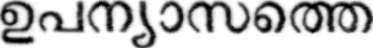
ഉപന്യാസത്തെ
